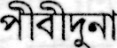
পীবীদুনা
